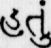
હતું
